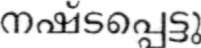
നഷ്ടപ്പെട്ടു
